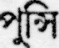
পুন্সি
